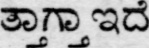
ತ್ತಾಗ್ತಾ ಇದೆ
